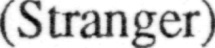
(Stranger)
